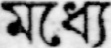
মধ্যে
